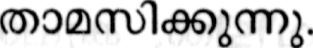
താമസിക്കുന്നു.
